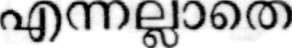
എന്നല്ലാതെ
